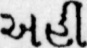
અહીં
